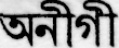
অনীগী
